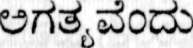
ಅಗತ್ಯವೆಂದು
